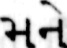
મને
